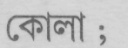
কোলা;
